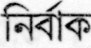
নির্বাক
